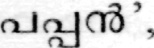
പപ്പന്‍’,
